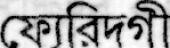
ফ্যেরিদগী
